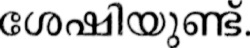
ശേഷിയുണ്ട്.
